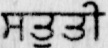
ਸਤੁਤੀ
